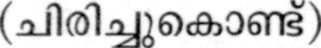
(ചിരിച്ചുകൊണ്ട്)
